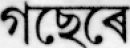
গছেৰে
